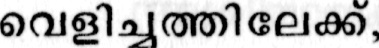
വെളിച്ചത്തിലേക്ക്,
